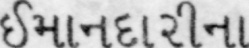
ઈમાનદારીના
